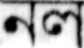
নল
